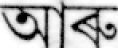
আৰু
